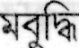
মবুদ্ধি
